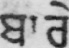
ਬਾਰੇ
